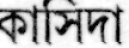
কাসিদা
